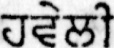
ਹਵੇਲੀ
